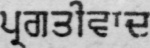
ਪ੍ਰਗਤੀਵਾਦ
